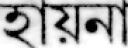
হায়না
